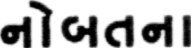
નોબતના
